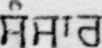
ਸੰਸਾਰ
